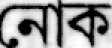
নোক
